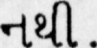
નથી.
